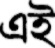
এই
